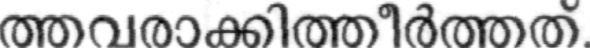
ത്തവരാക്കിത്തീര്‍ത്തത്.
